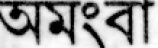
অমংবা
